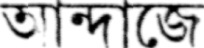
আন্দাজে
